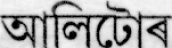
আলিটোৰ
